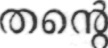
തന്റെ
